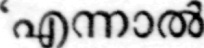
‘എന്നാല്‍
